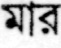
মার
